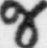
જ
